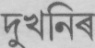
দুখনিৰ
